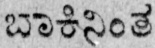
ಬಾಕಿನಿಂತ
